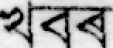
খবৰ
